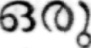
ഒരു
